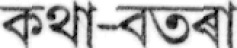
কথা-বতৰা
